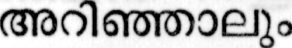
അറിഞ്ഞാലും
